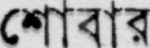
শোবার
